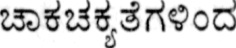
ಚಾಕಚಕ್ಯತೆಗಳಿಂದ
